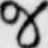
જ
